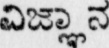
ವಿಜ್ಞಾನ
